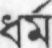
ধর্ম
